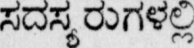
ಸದಸ್ಯರುಗಳಲ್ಲಿ
